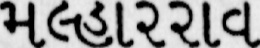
મલ્હારરાવ
